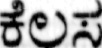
ಕೆಲಸ
